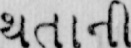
થતાની
